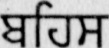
ਬਹਿਸ
